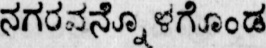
ನಗರವನ್ನೊಳಗೊಂಡ
